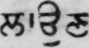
ਲਾਉਣ
